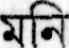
মনি
